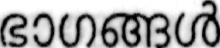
ഭാഗങ്ങള്‍
